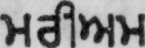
ਮਰੀਅਮ
